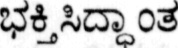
ಭಕ್ತಿಸಿದ್ಧಾಂತ
